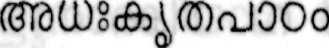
അധഃകൃതപാഠം
